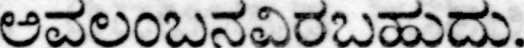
ಅವಲಂಬನವಿರಬಹುದು.
